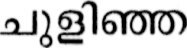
ചുളിഞ്ഞ
